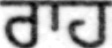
ਰਾਹ
